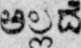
ಅಲ್ಲದೆ
